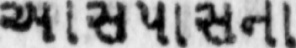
આસપાસના
